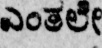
ಎಂತಲೇ
